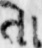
તો
